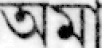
অমা
